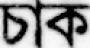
চাক
